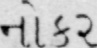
નોકર
